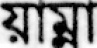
য়াম্না
